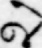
જે
